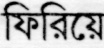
ফিরিয়ে
